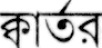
ক্বার্তর
